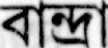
বান্দ্রা
